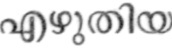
എഴുതിയ
